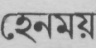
হেনময়
